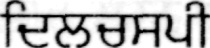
ਦਿਲਚਸਪੀ
